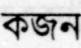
কজন
